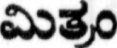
ಮಿತ್ರಂ
